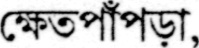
ক্ষেতপাঁপড়া,
